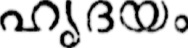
ഹൃദയം
